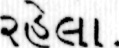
રહેલા.
